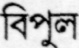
বিপুল
